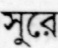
সুরে
